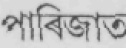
পাৰিজাত
